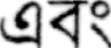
এবং
